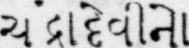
ચંદ્રાદેવીનો
